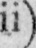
ii)
